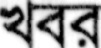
খবর
